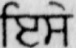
ਇਸੇ
